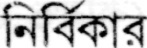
নির্বিকার
